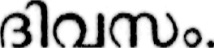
ദിവസം.
